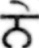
ਨੇ
